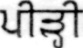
ਪੀੜ੍ਹੀ
